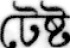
টেষ্ট
